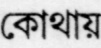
কোথায়
